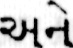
અને
